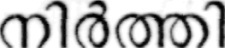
നിര്‍ത്തി
